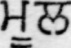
ਮੂਲ
